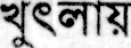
খুৎলায়
